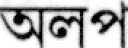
অলপ
